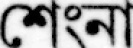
শেংনা
